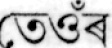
তেওঁৰ
